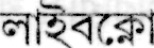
লাইবক্নো
